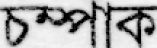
চম্পাক
